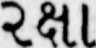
રક્ષા
